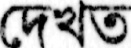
দেখত
